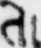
તો
